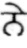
ਨੇ
